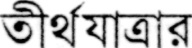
তীর্থযাত্রার
